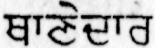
ਥਾਣੇਦਾਰ
